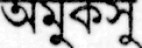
অমুকসু
